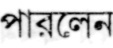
পারলেন
